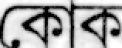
কোক
